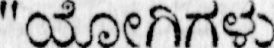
“ಯೋಗಿಗಳು
